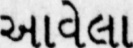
આવેલા
